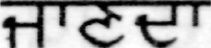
ਜਾਣਦਾ
